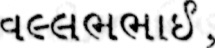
વલ્લભભાઈ,
